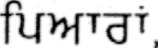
ਪਿਆਰਾਂ,
